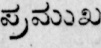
ಪ್ರಮುಖ
